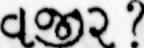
વજીર?
